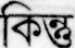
কিন্তু
